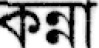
কন্না
